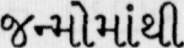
જન્મોમાંથી
